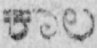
ಕಾಲ
